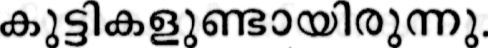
കുട്ടികളുണ്ടായിരുന്നു.
